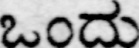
ಒಂದು
